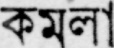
কমলা
